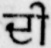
ਦੀ
